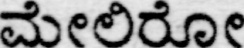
ಮೇಲಿರೋ
